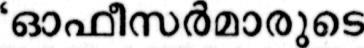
‘ഓഫീസര്‍മാരുടെ
